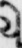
યે
